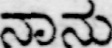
ನಾನು
